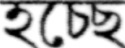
হচ্ছে
